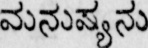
ಮನುಷ್ಯನು
